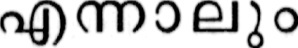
എന്നാലും
